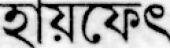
হায়ফেৎ
